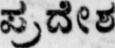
ಪ್ರದೇಶ
